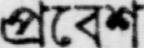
প্রবেশ
